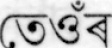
তেওঁৰ
